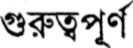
গুরুত্বপূর্ণ
